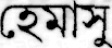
হেমাবু
